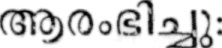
ആരംഭിച്ചു:
